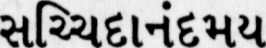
સચ્ચિદાનંદમય
